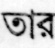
তার
